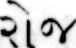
રોજ
